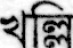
খল্লি
